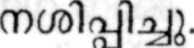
നശിപ്പിച്ചു.
